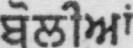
ਬੋਲੀਆਂ
